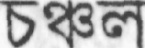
চঞ্চল
